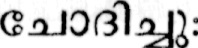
ചോദിച്ചു:
